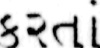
કરતાં
